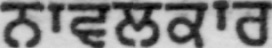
ਨਾਵਲਕਾਰ
